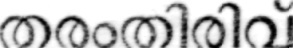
തരംതിരിവ്
